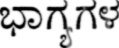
ಭಾಗ್ಯಗಳ
